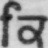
ਕਿ
